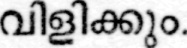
വിളിക്കും.
